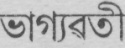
ভাগ্যৱতী
